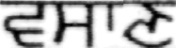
ਵਸਾਣ
